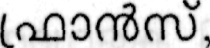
ഫ്രാന്‍സ്,
